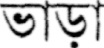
ভাড়া
